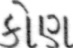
કોણ
